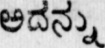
ಅದನ್ನು
